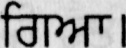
ਗਿਆ।
